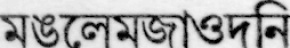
মঙলেমজাওদনি
